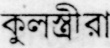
কুলস্ত্রীরা
